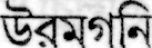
উরমগনি
